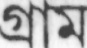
গ্রাম
